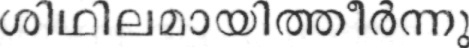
ശിഥിലമായിത്തീര്‍ന്നു
